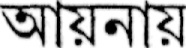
আয়নায়
